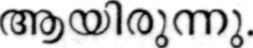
ആയിരുന്നു.
